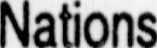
Nations
